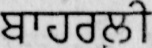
ਬਾਹਰਲੀ
